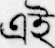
এই
